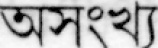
অসংখ্য
